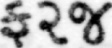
ફરજ
